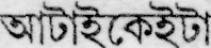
আটাইকেইটা
